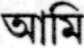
আমি
